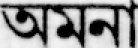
অমনা
